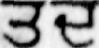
ਤਦ
